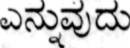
ಎನ್ನುವುದು
